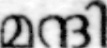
മന്ദി
